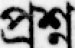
প্রশ্ন
